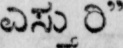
ಎಸ್ತುರಿ”
